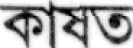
কাষত
